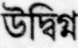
উদ্বিগ্ন
